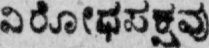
ವಿರೋಧಪಕ್ಷವು
